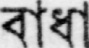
বাধা
